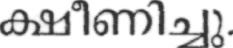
ക്ഷീണിച്ചു.
